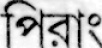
পিরাং
